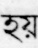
হয়
